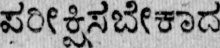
ಪರೀಕ್ಷಿಸಬೇಕಾದ
